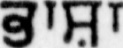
ਭਾਸ਼ਾ
